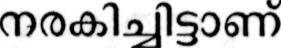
നരകിച്ചിട്ടാണ്
